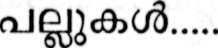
പല്ലുകള്‍.....
